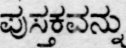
ಪುಸ್ತಕವನ್ನು
